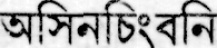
অসিনচিংবনি
